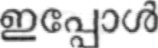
ഇപ്പോള്‍
